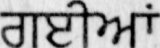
ਗਈਆਂ
